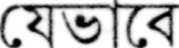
যেভাবে
